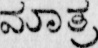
ಮಾತ್ರ
